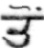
ਤੋਂ
